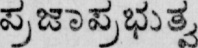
ಪ್ರಜಾಪ್ರಭುತ್ವ
